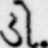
ડો.
